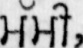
ਮੱਮੀ,
